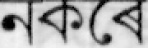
নকৰে
